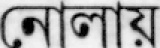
নোলায়
